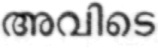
അവിടെ
